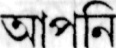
আপনি
